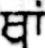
ਥਾਂ
